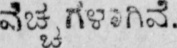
ವೆಚ್ಚಗಳಾಗಿವೆ.
